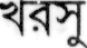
খরসু
